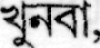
খুনবা,
